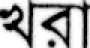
খরা
